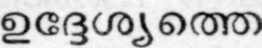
ഉദ്ദേശ്യത്തെ
